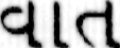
વાત
